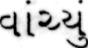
વાંચ્યું
